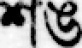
শঙ
